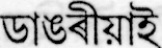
ডাঙৰীয়াই
